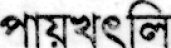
পায়খৎলি
